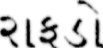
રાફડો
